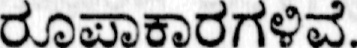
ರೂಪಾಕಾರಗಳಿವೆ.
